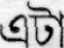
এটা
